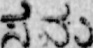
ಸಮ
